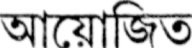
আয়োজিত
